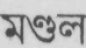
মণ্ডল
